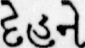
દેહને
